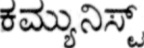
ಕಮ್ಯುನಿಸ್ಟ್
